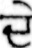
ਦੇ
